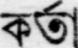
কর্তা
